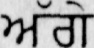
ਅੱਗੇ
